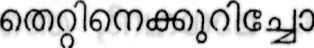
തെറ്റിനെക്കുറിച്ചോ
